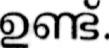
ഉണ്ട്.
